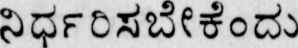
ನಿರ್ಧರಿಸಬೇಕೆಂದು
